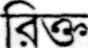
রিক্ত
